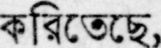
করিতেছে,
